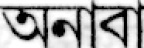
অনাবা
